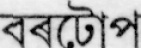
বৰটোপ
